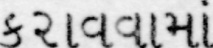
કરાવવામાં
